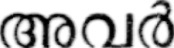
അവര്‍
